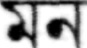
মন
